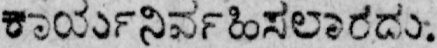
ಕಾರ್ಯನಿರ್ವಹಿಸಲಾರದು.
